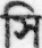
সি
